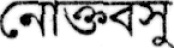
নোক্তবসু
